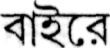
বাইরে
